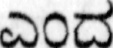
ಎಂದ
